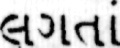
લગતાં
